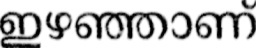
ഇഴഞ്ഞാണ്
